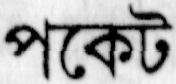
পকেট
